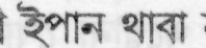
ইপান থাপা
